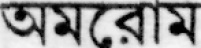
অমরোম
